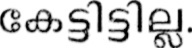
കേട്ടിട്ടില്ല.
